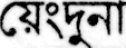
য়েংদুনা
